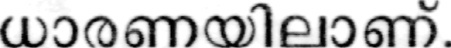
ധാരണയിലാണ്.
